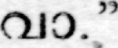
വാ."
